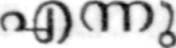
എന്നു
